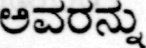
ಅವರನ್ನು
